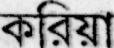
করিয়া
